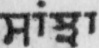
ਸਾਂਝਾ
